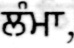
ਲੰਮਾ,
